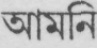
আমনি
